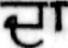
ਦਾ
